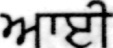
ਆਈ
